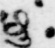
છું.
